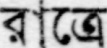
রাত্রে
